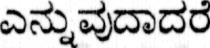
ಎನ್ನುವುದಾದರೆ
